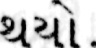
થયો.
